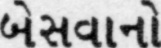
બેસવાનો
